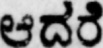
ಆದರೆ
